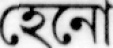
হেনো
